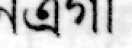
নত্রগা
